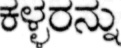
ಕಳ್ಳರನ್ನು
